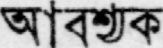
আবশ্যক
